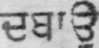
ਦਬਾਉ
